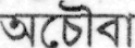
অচৌবা
